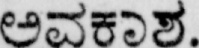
ಅವಕಾಶ.
